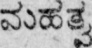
ಮಹತ್ವ
